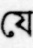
যে
